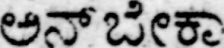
ಅನ್ ಬೇಕಾ
